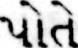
પોતે
